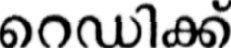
റെഡിക്ക്
